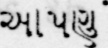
આપણું
